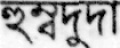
হুম্বদুদা
